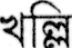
খল্লি
